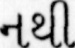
નથી
